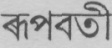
ৰূপবতী
